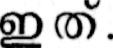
ഇത്.
